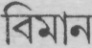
বিমান
